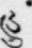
હું
